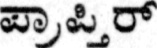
ಪ್ರಾಪ್ತಿರ್
